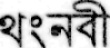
থংনবী
